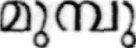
മുമ്പു
